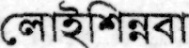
লোইশিন্নবা
